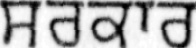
ਸਰਕਾਰ
